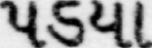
પડયા
